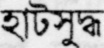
হাটসুদ্ধ
